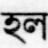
হল
